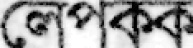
লেপকক
